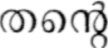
തന്റെ
